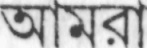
আমরা
